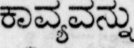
ಕಾವ್ಯವನ್ನು
